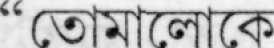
"তোমালোকে
